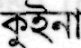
কুইনা
